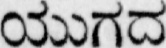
ಯುಗದ
